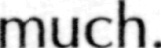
much.
